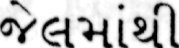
જેલમાંથી
